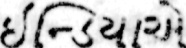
ઇન્ડિયાએ
